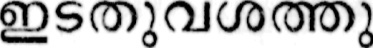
ഇടതുവശത്തു
